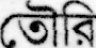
তৌরি
